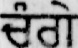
ਚੰਗੇ
